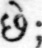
છે;
